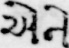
એને
